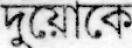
দুয়োকে
